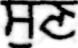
ਸੁਣ
